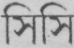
সিসি
